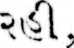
રહી,
